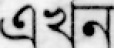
এখন
